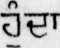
ਹੁੰਦਾ
